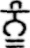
ਨੂੰ
